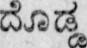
ದೊಡ್ಡ
